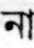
না
